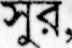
সুর,
